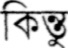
কিন্তু
